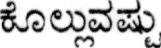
ಕೊಲ್ಲುವಷ್ಟು
